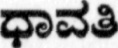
ಧಾವತಿ
